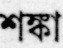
শঙ্কা
